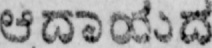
ಆದಾಯದ
